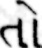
તો
